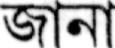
জানা
